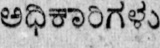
ಅಧಿಕಾರಿಗಳು
